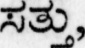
ಸತ್ತು,
